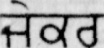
ਜੇਕਰ
